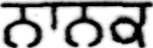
ਨਾਨਕ
